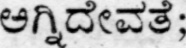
ಅಗ್ನಿದೇವತೆ;
